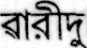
ৱারীদু
